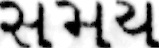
સમય
